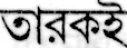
তারকই
